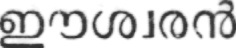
ഈശ്വരന്‍
